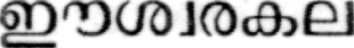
ഈശ്വരകല
